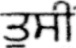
ਤੁਸੀਂ
